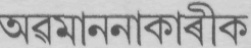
অৱমাননাকাৰীক
